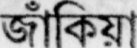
জাঁকিয়া
